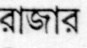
রাজার
